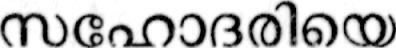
സഹോദരിയെ
